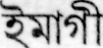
ইমাগী
